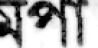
মপা
